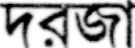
দরজা
